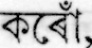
কৰোঁ,
